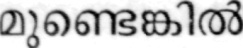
മുണ്ടെങ്കില്‍
